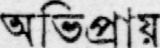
অভিপ্রায়
